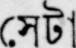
সেটা
